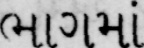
ભાગમાં
